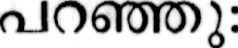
പറഞ്ഞു:
